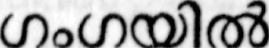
ഗംഗയില്‍
